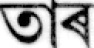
তাৰ
